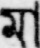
মা
